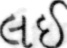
લઈ
